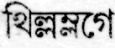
থিল্লম্লগে
